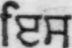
ਇਸ
